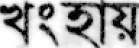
খংহায়
